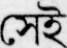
সেই
